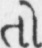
તો
